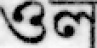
ওল
